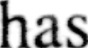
has
